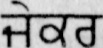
ਜੇਕਰ
